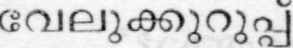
വേലുക്കുറുപ്പ്
